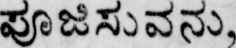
ಪೂಜಿಸುವನು,
